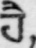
ਹੈ,
